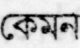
কেমন
